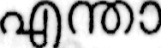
എന്താ
